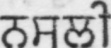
ਨਸਲੀ
